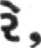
રે,
